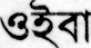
ওইবা
